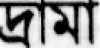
দ্রামা
